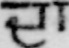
ਦਾ
